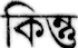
কিন্তু
